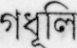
গধূলি
